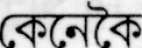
কেনেকৈ
